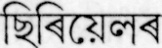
ছিৰিয়েলৰ
